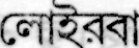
লোইরবা
